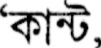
'কান্ট,
